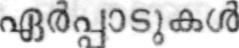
ഏര്‍പ്പാടുകള്‍
